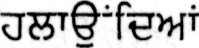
ਹਲਾਉਂਦਿਆਂ
